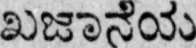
ಖಜಾನೆಯ
